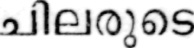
ചിലരുടെ
